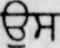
ਉਸ
